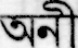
অনী
